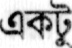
একটু
